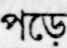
পড়ে
